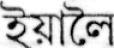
ইয়ালৈ
